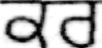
ਕਰ
